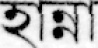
হান্না
